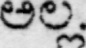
ಅಲ್ಲ.
